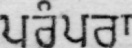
ਪਰੰਪਰਾ
